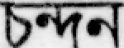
চন্দন
